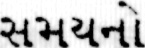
સમયનો
